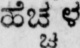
ಹೆಚ್ಚಳ
